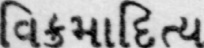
વિક્રમાદિત્ય
